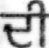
ਦੀ
